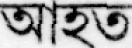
আহত
